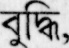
বুদ্ধি,
